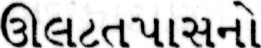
ઊલટતપાસનો
